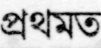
প্রথমত
